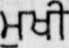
ਮੁਖੀ
